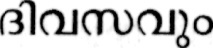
ദിവസവും
